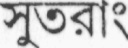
সুতরাং
